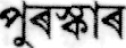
পুৰস্কাৰ
